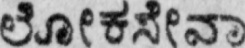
ಲೋಕಸೇವಾ
